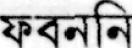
ফবননি
